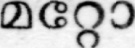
മറ്റോ
